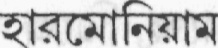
হারমোনিয়াম
